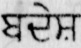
ਬਦੇਸ਼
